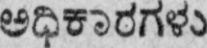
ಅಧಿಕಾರಗಳು
